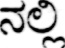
ನಲ್ಲಿ
